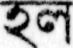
হল
